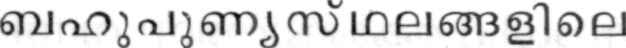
ബഹുപുണ്യസ്ഥലങ്ങളിലെ
